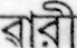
ৱারী
